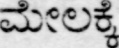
ಮೇಲಕ್ಕೆ
